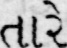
તારે
